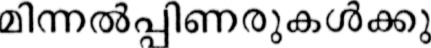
മിന്നല്‍പ്പിണരുകള്‍ക്കു
